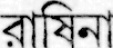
রাষিনা
